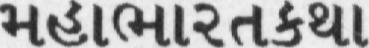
મહાભારતકથા
